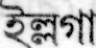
ইল্লগা
